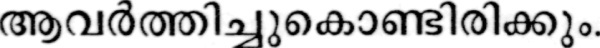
ആവര്‍ത്തിച്ചുകൊണ്ടിരിക്കും.
